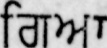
ਗਿਆ
